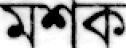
মশক
